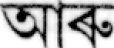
আৰু
